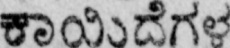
ಕಾಯಿದೆಗಳ
